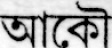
আকৌ
